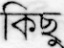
কিছু
